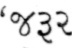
'જરૂર
